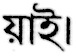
য়াই।
